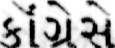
કૉંગ્રેસે
